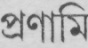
প্ৰণামি
